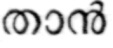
താന്‍
